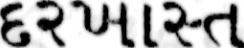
દરખાસ્ત
